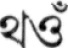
থওঁ
